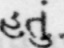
હતું.
